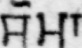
ਸੋਮਾ
